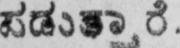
ಪಡುತ್ತಾರೆ.
